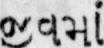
જીવમાં
